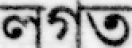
লগত
